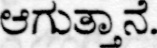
ಆಗುತ್ತಾನೆ.
